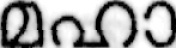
മഹാ
